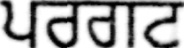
ਪਰਗਟ
